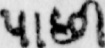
પાછી
